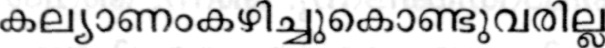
കല്യാണംകഴിച്ചുകൊണ്ടുവരില്ല
